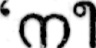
‘നീ
